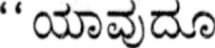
"ಯಾವುದೂ
